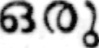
ഒരു
